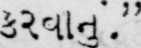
કરવાનું."
